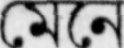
মেনে
